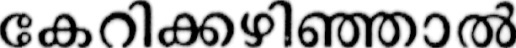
കേറിക്കഴിഞ്ഞാല്‍
